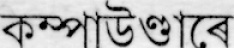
কম্পাউণ্ডাৰে
